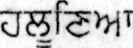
ਹਲੂਣਿਆ
